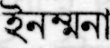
ইনম্মনা
